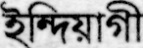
ইন্দিয়াগী
